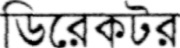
ডিরেকটর
